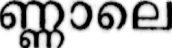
ണ്ണാലെ
